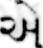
એ
